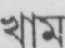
খাম
